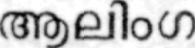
ആലിംഗ
